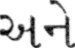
અને
